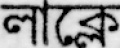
লাক্লে
